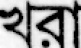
খরা
